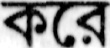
করে
